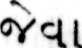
જેવા
